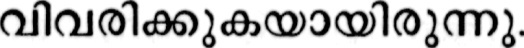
വിവരിക്കുകയായിരുന്നു.
